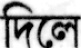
দিলে
